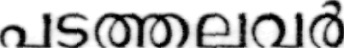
പടത്തലവര്‍
